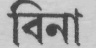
বিনা
